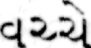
વચ્ચે
